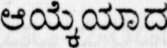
ಆಯ್ಕೆಯಾದ
